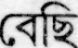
বেছি
